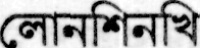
লোনশিনখি
